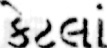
કેટલાં
